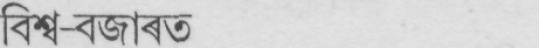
বিশ্ব-বজাৰত
